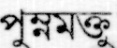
পুম্নমক্তু
